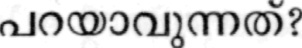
പറയാവുന്നത്?
